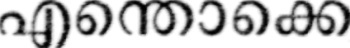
എന്തൊക്കെ
